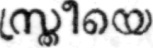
സ്ത്രീയെ
